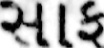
સાફ
